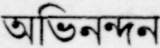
অভিনন্দন
